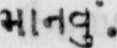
માનવું.
